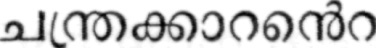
ചന്ത്രക്കാറന്റെ
